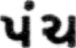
પંચ
